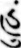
હું
